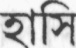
হাসি
